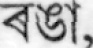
ৰঙা,
